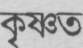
কৃষ্ণত
